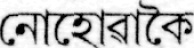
নোহোৱাকৈ
